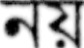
নয়
